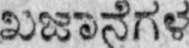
ಖಜಾನೆಗಳ
